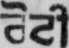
ਰੋਟੀ
